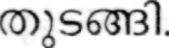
തുടങ്ങി.
